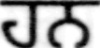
ਹਨ
